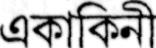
একাকিনী
